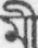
মী
